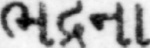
ભદ્રના
